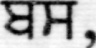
ਬਸ,
